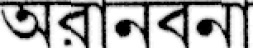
অরানবনা
